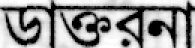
ডাক্তরনা
